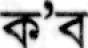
ক'ব
